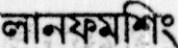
লানফমশিং
